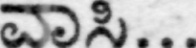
ವಾಸಿ...
